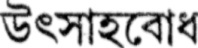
উৎসাহবোধ
